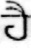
ਹੈ
